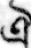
ঐ
